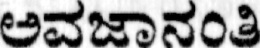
ಅವಜಾನಂತಿ
